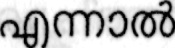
എന്നാല്‍
